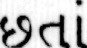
છતાં
